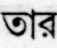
তার
